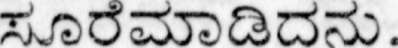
ಸೂರೆಮಾಡಿದನು.
